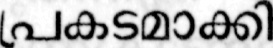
പ്രകടമാക്കി
